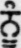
ਨੂੰ
